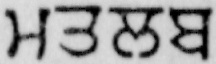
ਮਤਲਬ
